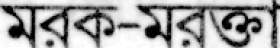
মরক-মরক্তা
